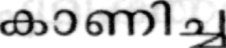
കാണിച്ച
